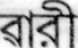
ৱারী
